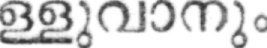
ള്ളുവാനും
